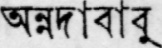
অন্নদাবাবু
